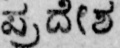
ಪ್ರದೇಶ
